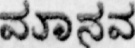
ಮಾನವ
